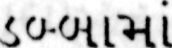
ડબ્બામાં
